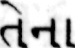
તેના
